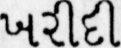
ખરીદી
